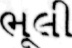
ભૂલી
